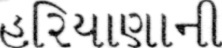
હરિયાણાની
